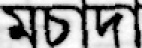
মচাদা
